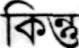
কিন্তু
